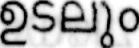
ഉടലും
